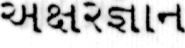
અક્ષરજ્ઞાન
